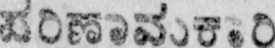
ಪರಿಣಾಮಕಾರಿ
